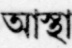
আস্থা
